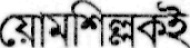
য়োমশিল্লমই
